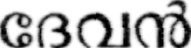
ദേവന്‍
